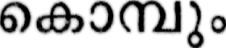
കൊമ്പും
